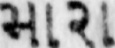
મારા
